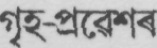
গৃহ-প্ৰৱেশৰ
